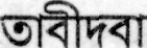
তাবীদবা
